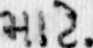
માટે.
